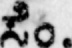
ಸೆಂ.
